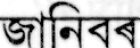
জানিবৰ
